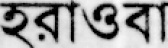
হরাওবা
